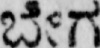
ಬೇಗ
